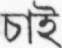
চাই
